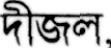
দীজল,
